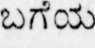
ಬಗೆಯ
